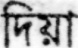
দিয়া
